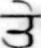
ਤੇ
